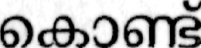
കൊണ്ട്
